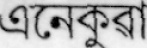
এনেকুৱা
